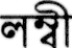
লম্বী
